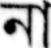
না
